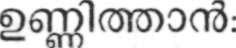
ഉണ്ണിത്താന്‍:
